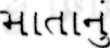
માતાનું
